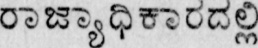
ರಾಜ್ಯಾಧಿಕಾರದಲ್ಲಿ
